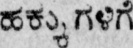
ಹಕ್ಕುಗಳಿಗೆ
